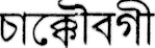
চাক্কৌবগী
